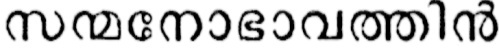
സന്മനോഭാവത്തിന്‍
